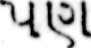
પણ
